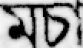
মচা
